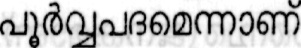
പൂര്‍വ്വപദമെന്നാണ്
